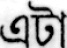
এটা
